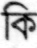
কি
